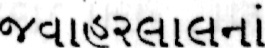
જવાહરલાલનાં
